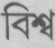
বিশ্ব
